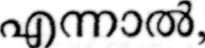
എന്നാല്‍,
